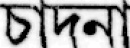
চাদনা
